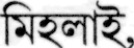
মিহলাই,
